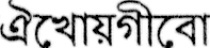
ঐখোয়গীবো
